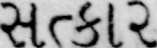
સત્કાર
